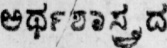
ಅರ್ಥಶಾಸ್ತ್ರದ
